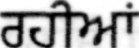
ਰਹੀਆਂ
